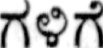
ಗಳಿಗೆ
